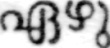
ഏഴു
